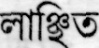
লাঞ্ছিত
